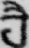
ਹੈ
